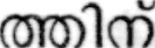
ത്തിന്
